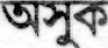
অসুক
